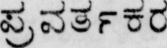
ಪ್ರವರ್ತಕರ
